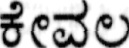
ಕೇವಲ
